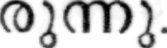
രുന്നു.
